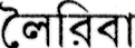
লৈরিবা
